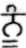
ਨੂੰ
